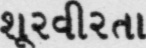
શૂરવીરતા
